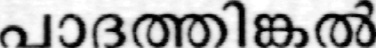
പാദത്തിങ്കല്‍
